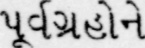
પૂર્વગ્રહોને
